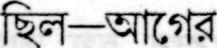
ছিল—আগের
